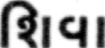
શિવા
